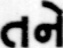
તને
